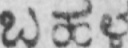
ಬಹಳ
